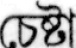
চেষ্টা
